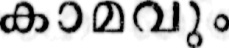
കാമവും
